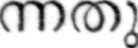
ന്നതു
